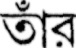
তাঁর
